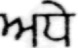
ਅਧੇ
